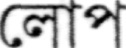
লোপ
